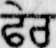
ਫੇਰ
